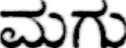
ಮಗು
